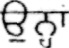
ਉਨ੍ਹਾਂ
